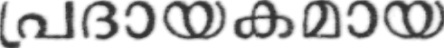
പ്രദായകമായ
